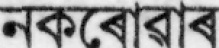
নকৰোৱাৰ
